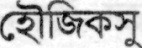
হৌজিকসু
